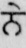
ਨੇ
